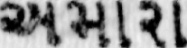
અમારા
